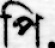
পি.
